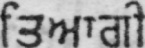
ਤਿਆਗੀ
